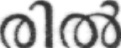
രില്‍
